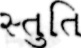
સ્તુતિ
